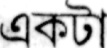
একটা
